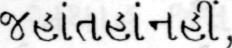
જહાંતહાંનહીં,
